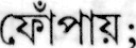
ফোঁপায়;
